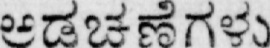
ಅಡಚಣೆಗಳು
